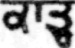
ਕਾੜ੍ਹ
